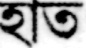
হাত
